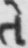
તે
